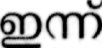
ഇന്ന്
